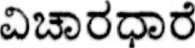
ವಿಚಾರಧಾರೆ
